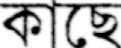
কাছে
